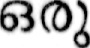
ഒരു
